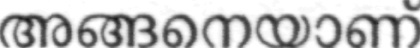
അങ്ങനെയാണ്
